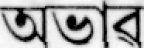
অভাৱ
